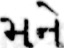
મને
